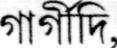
গার্গীদি,
